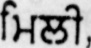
ਮਿਲੀ,
